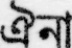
ঐনা
